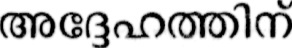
അദ്ദേഹത്തിന്
